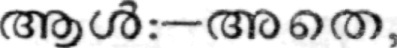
ആള്‍:-അതെ,
